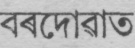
বৰদোৱাত
